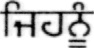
ਜਿਹਨੂੰ
